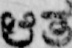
ಆತ
